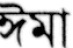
ঈমা
